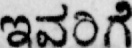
ಇವರಿಗೆ
